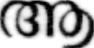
ആ
